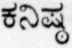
ಕನಿಷ್ಠ
